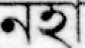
নহা
